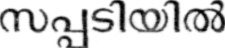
സപ്പടിയില്‍
